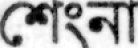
শেংনা
